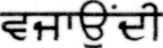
ਵਜਾਉਂਦੀ
